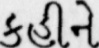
કહીને
